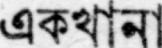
একখানা
